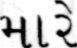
મારે
